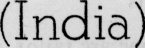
(India)
